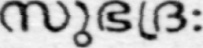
സുഭദ്ര:
